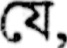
যে,
